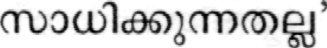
സാധിക്കുന്നതല്ല’
